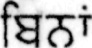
ਬਿਨਾਂ
